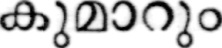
കുമാറും
